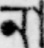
না
